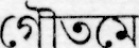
গৌতমে
